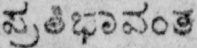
ಪ್ರತಿಭಾವಂತ
